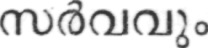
സര്‍വവും
